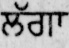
ਲੱਗਾ
